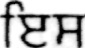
ਇਸ
